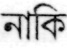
নাকি
